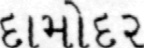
દામોદર
